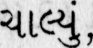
ચાલ્યું,
